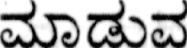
ಮಾಡುವ
